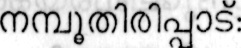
നമ്പൂതിരിപ്പാട്:
